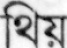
থিয়
